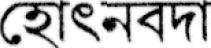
হোৎনবদা
